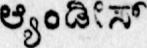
ಆಂಡೀಸ್
